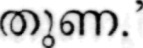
തുണ.'
